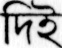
দিই
